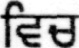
ਵਿਚ
